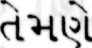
તેમણે
